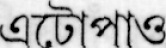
এটোপাও
